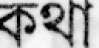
কথা
